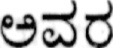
ಅವರ
